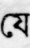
যে
